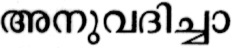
അനുവദിച്ചാ
